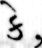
કે,
